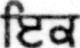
ਇਕ
